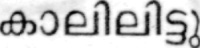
കാലിലിട്ടു
